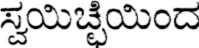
ಸ್ವಯಿಚ್ಛೆಯಿಂದ
